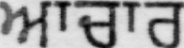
ਆਚਾਰ
